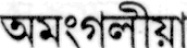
অমংগলীয়া
